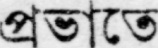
প্রভাতে
